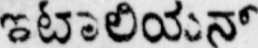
ಇಟಾಲಿಯನ್
